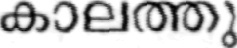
കാലത്തു
